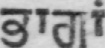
ਭਾਗਾਂ
